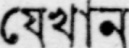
যেখান
